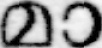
മാ
